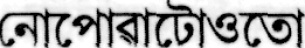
নোপোৱাটোওতো
